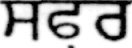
ਸਫ਼ਰ
